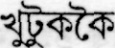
খুটুককৈ
